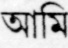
আমি
